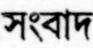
সংবাদ
